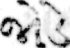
જોડે
